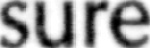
sure
